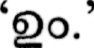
‘ഉം.'
